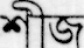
শীজ
